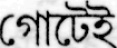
গোটেই
